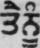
ਤੈਨੂੰ
